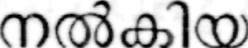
നല്‍കിയ
